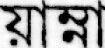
য়াম্না
